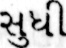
સુધી
